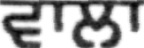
ਵਾਲਾ
